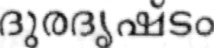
ദുരദൃഷ്ടം
